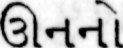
ઊનનો
